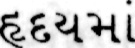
હ્રદયમાં
